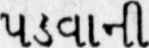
પડવાની
